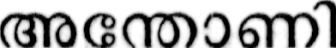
അന്തോണി
